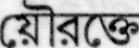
য়ৌরক্তে
